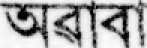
অৱাবা
